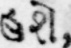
હશે,
